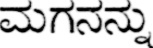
ಮಗನನ್ನು
